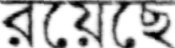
রয়েছে
